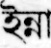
ইন্না
